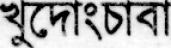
খুদোংচাবা
